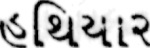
હથિયાર
